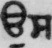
ਉਸ
